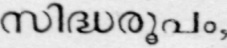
സിദ്ധരൂപം,
